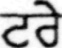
ਟਰੇ
